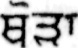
ਥੋੜਾ
